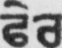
ਫੇਰ
